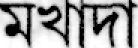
মখাদা
